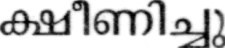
ക്ഷീണിച്ചു
